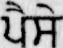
ਪੈਸੇ
